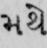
મથે
